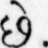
છે.
